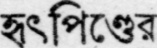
হৃৎপিণ্ডের
